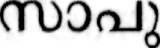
സാപു
